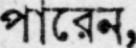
পারেন,
